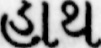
હાથ
